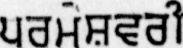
ਪਰਮੇਸ਼ਵਰੀ
